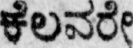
ಕೆಲವರೇ
